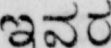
ಇವರ
